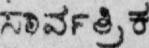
ಸಾರ್ವತ್ರಿಕ
